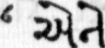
'એને
